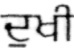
ਦੁਖੀ
